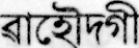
ৱাহৌদগী
